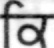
ਕਿ
